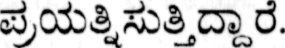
ಪ್ರಯತ್ನಿಸುತ್ತಿದ್ದಾರೆ.
